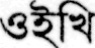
ওইখি
